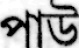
পাউ
